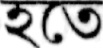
হতে
